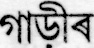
গাড়ীৰ
